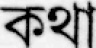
কথা
